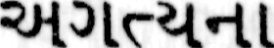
અગત્યના
